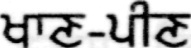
ਖਾਣ-ਪੀਣ
